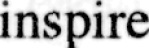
inspire
